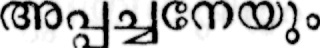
അപ്പച്ചനേയും
